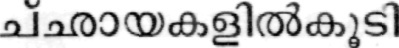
ച്ഛായകളില്‍കൂടി
